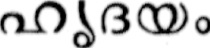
ഹൃദയം
